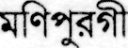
মণিপুরগী
